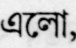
এলো,
